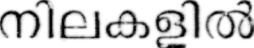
നിലകളില്‍
